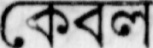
কেবল
